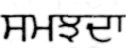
ਸਮਝਦਾ
